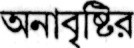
অনাবৃষ্টির
